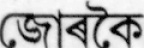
জোৰকৈ
